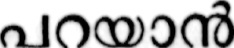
പറയാന്‍
